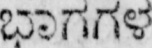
ಭಾಗಗಳ
